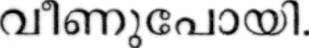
വീണുപോയി.
